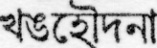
খঙহৌদনা
